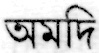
অমদি
